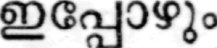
ഇപ്പോഴും
